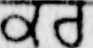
ਕਰ
